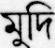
মুদি
